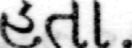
હતા.
